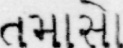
તમાસો
